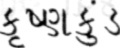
કૃષ્ણકુંડ
